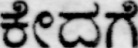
ಕೇದಗೆ
